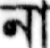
না
